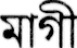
মাগী
